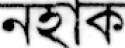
নহাক
